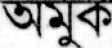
অমুক
